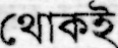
থোকই
